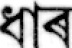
ধাৰ
